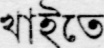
খাইতে
